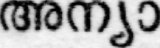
അന്യാ
